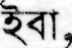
ইবা,
